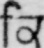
ਕਿ
